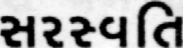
સરસ્વતિ
